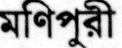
মণিপুরী
